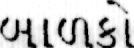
બાળકો
